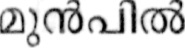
മുന്‍പില്‍
